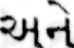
અને
